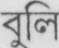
বুলি
